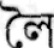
লৈ
